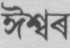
ঈশ্বৰ
